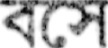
বসে
